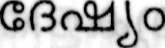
ദേഷ്യം
